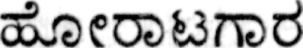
ಹೋರಾಟಗಾರ
